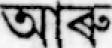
আৰু
